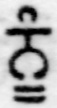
ਨੂੰ
